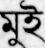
মুই
